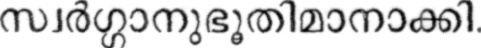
സ്വര്‍ഗ്ഗാനുഭൂതിമാനാക്കി.
